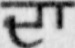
ਦਾ
